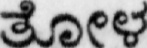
ತೋಳ
